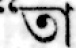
“তা
